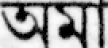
অমা
